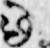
છે.
